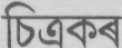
চিত্রকৰ
